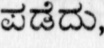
ಪಡೆದು,
